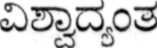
ವಿಶ್ವಾದ್ಯಂತ
